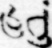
હતું
